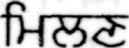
ਮਿਲਣ
